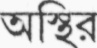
অস্থির
